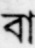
বা
